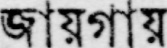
জায়গায়
